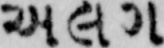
અલગ
